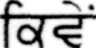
ਕਿਵੇਂ
